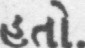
હતો.
